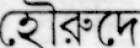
হৌরুদে
